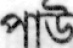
পাউ
